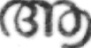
ആ
